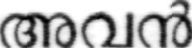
അവന്‍
